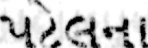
પટેલના
